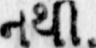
નથી.
